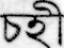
চহী
